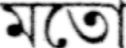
মতো
